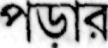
পড়ার
